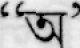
"অ'
